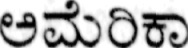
ಅಮೆರಿಕಾ
